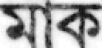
মাক
